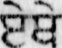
ਏਥੇ
